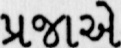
પ્રજાએ
